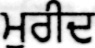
ਮੁਰੀਦ
